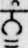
ਨੂੰ
